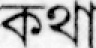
কথা
